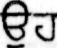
ਉਹ
